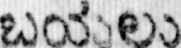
ಬಯಲು
